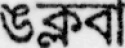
ঙক্লবা
